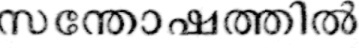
സന്തോഷത്തില്‍
